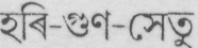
হৰি-গুণ-সেতু
